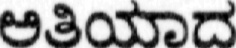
ಅತಿಯಾದ
